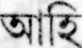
আহি
